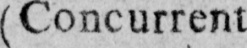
(Concurrent
